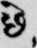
છે,
